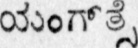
ಯಂಗ್‌ತ್ಸೆ
